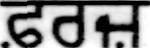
ਫ਼ਰਜ਼
